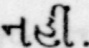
નહીં.
